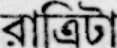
রাত্রিটা
